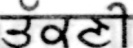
ਤੱਕਣੀ
